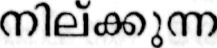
നില്ക്കുന്ന
